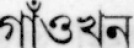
গাঁওখন
